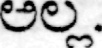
ಅಲ್ಲ.
